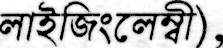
লাইজিংলেম্বী),
